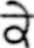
ਕੇ
